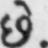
છે.
